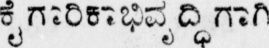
ಕೈಗಾರಿಕಾಭಿವೃದ್ಧಿಗಾಗಿ
